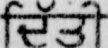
ਦਿੱਤੀ
